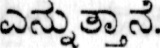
ಎನ್ನುತ್ತಾನೆ.
